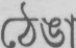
ঠেঙা
